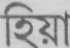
হিয়া
